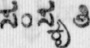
ಸಂಸ್ಕೃತಿ
